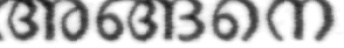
അങ്ങനെ
